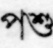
পশু
